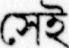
সেই
